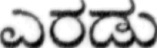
ಎರಡು
